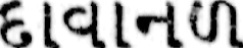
દાવાનળ
